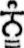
ਨੂੰ
